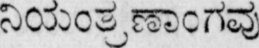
ನಿಯಂತ್ರಣಾಂಗವು
